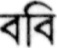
ববি
